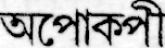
অপোকপী
